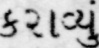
કરાવ્યું
